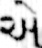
એ
